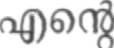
എന്റെ
